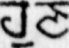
ਹੁਣ
